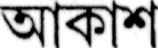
আকাশ
